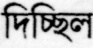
দিচ্ছিল
